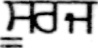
ਸੂਰਜ
